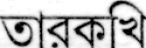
তারকখি
